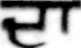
ਦਾ
